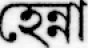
হেন্না
